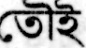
তৌই
